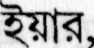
ইয়ার,
